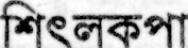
শিৎলকপা
